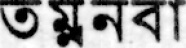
তম্ননবা
